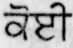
ਕੋਈ
